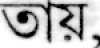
তায়,
